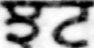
ਝਟ
